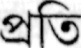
প্রতি
